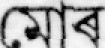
মোৰ
